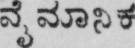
ವೈಮಾನಿಕ
